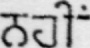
ਨਹੀਂ
